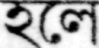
হলে
